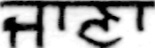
ਜਾਣਾ
